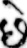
છે
